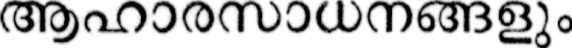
ആഹാരസാധനങ്ങളും
